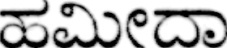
ಹಮೀದಾ
